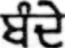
ਬੰਦੇ
